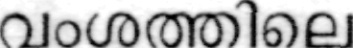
വംശത്തിലെ
